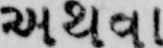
અથવા
